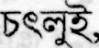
চৎলুই,
